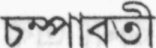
চম্পাবতী
